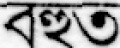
বহুত
